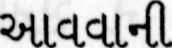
આવવાની
